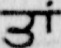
ਤਾਂ
